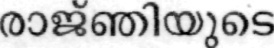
രാജ്ഞിയുടെ
